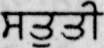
ਸਤੁਤੀ
